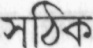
সঠিক
